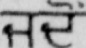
ਜਦੋਂ
